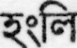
হংলি
